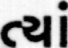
ત્યાં
